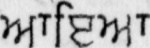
ਆਇਆ
